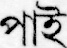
পাই
